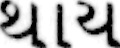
થાય
